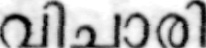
വിചാരി
